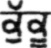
ਕੁੱਕੂ
